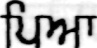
ਪਿਆ
